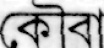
কৌবা
